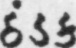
ઠંડક
